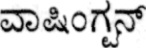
ವಾಷಿಂಗ್ಟನ್
